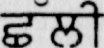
ਛੱਲੀ
